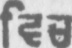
ਵਿਚ
